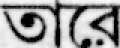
তারে
